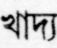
খাদ্য
